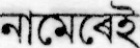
নামেৰেই
